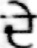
ਦੇ
